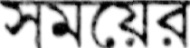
সময়ের
